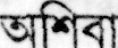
অশিবা
